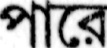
পারে
